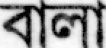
বালা
